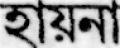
হায়না
